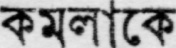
কমলাকে
